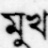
মুখ
